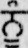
ਨੂੰ
